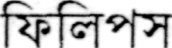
ফিলিপস
